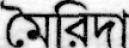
মৈরিদা
